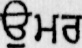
ਉਮਰ
